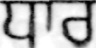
ਧਾਰ
